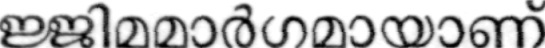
ജ്ജിമമാര്‍ഗമായാണ്
